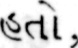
હતો,
